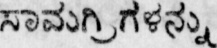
ಸಾಮಗ್ರಿಗಳನ್ನು
